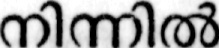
നിന്നില്‍
